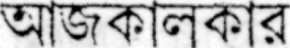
আজকালকার
